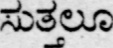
ಸುತ್ತಲೂ
